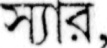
স্যার,
